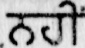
ਨਹੀਂ
